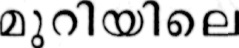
മുറിയിലെ
